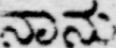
ನಾನು
